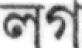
লগ
